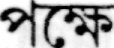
পক্ষে
